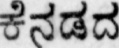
ಕೆನಡದ
